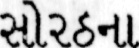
સોરઠના
